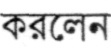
করলেন
